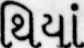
થિયાં
